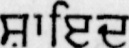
ਸ਼ਾਇਦ
